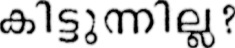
കിട്ടുന്നില്ല?
